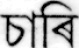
চাৰি
